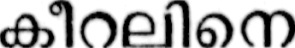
കീറലിനെ
